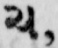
ચ,
